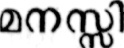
മനസ്സി
